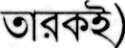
তারকই)
